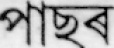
পাছৰ
